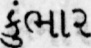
કુંભાર
